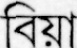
বিয়া
